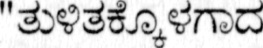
“ತುಳಿತಕ್ಕೊಳಗಾದ
